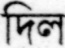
দিল
